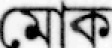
মোক
